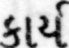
કાર્ય
